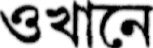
ওখানে
